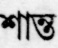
শান্ত
